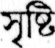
সৃষ্টি
